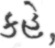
કહે,
